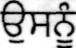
ਉਸਨੂੰ
